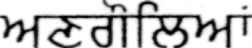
ਅਣਗੌਲਿਆਂ
